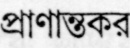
প্রাণান্তকর
